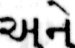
અને
